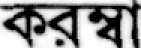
করম্বা
